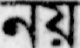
নয়
